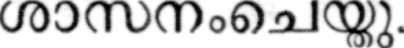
ശാസനംചെയ്തു.
